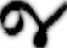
જ
